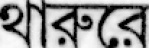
থারুরে
